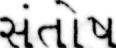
સંતોષ
